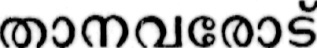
താനവരോട്
